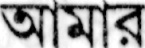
আমার
